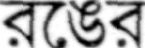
রঙের
